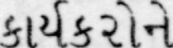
કાર્યકરોને
